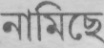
নামিছে
